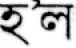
হ'ল
